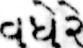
વધેરે
